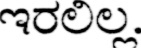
ಇರಲಿಲ್ಲ.
